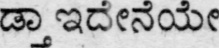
ಡ್ತಾಇದೇನೆಯೇ
